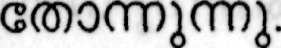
തോന്നുന്നു.
